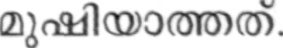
മുഷിയാത്തത്.
